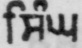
ਸਿੰਘ
